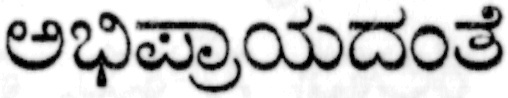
ಅಭಿಪ್ರಯಾದಂತೆ
